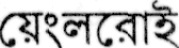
য়েংলরোই
